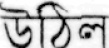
উঠিল
